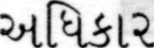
અધિકાર
